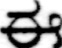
ಈ
